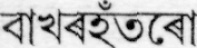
বাখৰহঁতৰো
